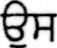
ਉਸ
